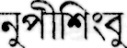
নুপীশিংবু
